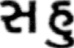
સહુ
